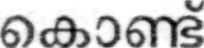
കൊണ്ട്
